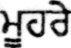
ਮੂਹਰੇ
